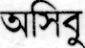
অসিবু
